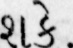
શકે.
